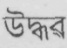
উদ্ধৱ
